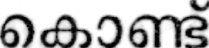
കൊണ്ട്
